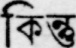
কিন্তু
